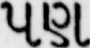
પણ
